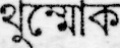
থুম্মোক
